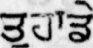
ਤੁਹਾਡੇ
